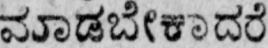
ಮಾಡಬೇಕಾದರೆ
